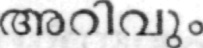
അറിവും
